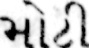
મોટી
